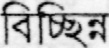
বিচ্ছিন্ন
